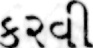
કરવી
